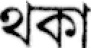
থকা
